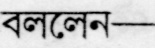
বললেন–
